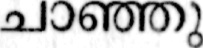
ചാഞ്ഞു
